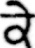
ਕੇ
